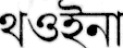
থওইনা
